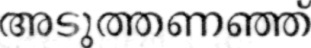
അടുത്തണഞ്ഞ്
